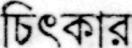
চিৎকার
